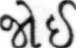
જોઈ
